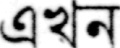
এখন
